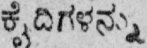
ಕೈದಿಗಳನ್ನು
